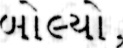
બોલ્યો,.'
